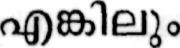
എങ്കിലും
